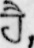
ਹੈ,
